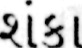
શંકા
